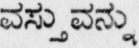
ವಸ್ತುವನ್ನು
